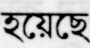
হয়েছে
